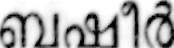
ബഷീര്‍
